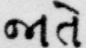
જતે
